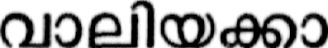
വാലിയക്കാ
